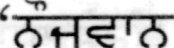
'ਨੌਜਵਾਨ
